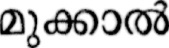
മുക്കാല്‍
